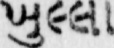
ખુલ્લા
